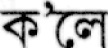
ক'লে
